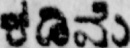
ಕಡಿಮೆ
